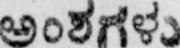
ಅಂಶಗಳು
